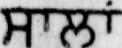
ਸਾਲਾਂ
